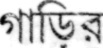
গাড়ির
